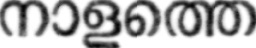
നാളത്തെ
